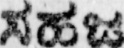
ಸಹಜ
